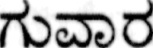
ಗುವಾರ
